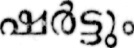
ഷര്‍ട്ടും
